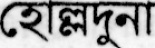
হোল্লদুনা
